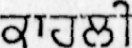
ਕਾਹਲੀ
